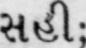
સહી;
